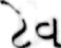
ટેવ
